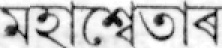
মহাশ্বেতাৰ
